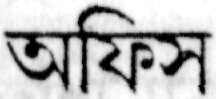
অফিস
